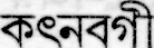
কৎনবগী
